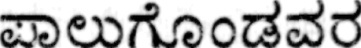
ಪಾಲುಗೊಂಡವರ
